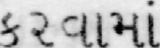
કરવામાં
